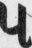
પ
